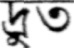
দ্রুত
